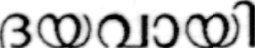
ദയവായി
